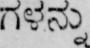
ಗಳನ್ನು
